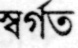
স্বর্গত
